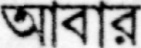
আবার
